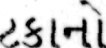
ટકાનો
